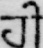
ਹੀ
